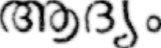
ആദ്യം
